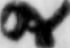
જ
